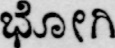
ಭೋಗಿ
